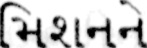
મિશનને
